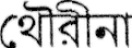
থৌরীনা
